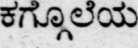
ಕಗ್ಗೊಲೆಯ
